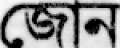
জোন
